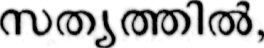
സത്യത്തില്‍,
